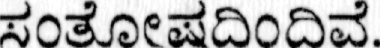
ಸಂತೋಷದಿಂದಿವೆ.
